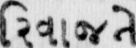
રિવાજને
